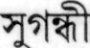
সুগন্ধী
